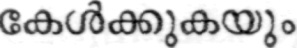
കേള്‍ക്കുകയും
